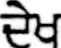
ਦੇਖ
